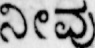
ನೀವು
